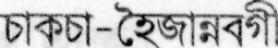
চাকচা-হৈজান্নবগী
